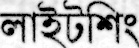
লাইটশিং
